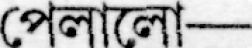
পেলালো-
